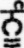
ਨੂੰ
